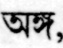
অঙ্গ,
